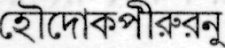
হৌদোকপীরুরনু
